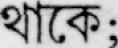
থাকে;
